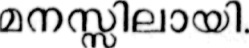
മനസ്സിലായി.
